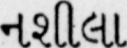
નશીલા
